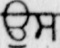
ਉਸ
